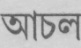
আচল
